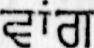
ਵਾਂਗ
